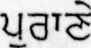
ਪੁਰਾਣੇ
